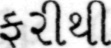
ફરીથી
